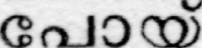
പോയ്
